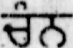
ਚੰਨ
